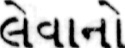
લેવાનો
